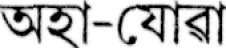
অহা-যোৱা
